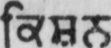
ਕਿਸ਼ਨ
